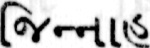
જિન્નાહ
